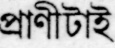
প্রাণীটাই
